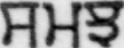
ਸਮਝ
